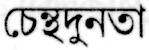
চেন্থদুনতা
